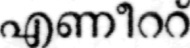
എണീററ്
